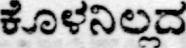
ಕೊಳನಿಲ್ಲದ
